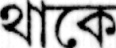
থাকে
